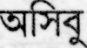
অসিবু
